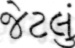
જેટલું
